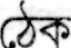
ঠেক
